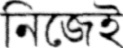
নিজেই
